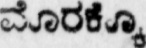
ಮೊರಕ್ಕೊ
